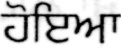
ਹੋਇਆ
